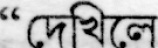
"দেখিলে
